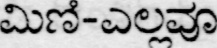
ಮಿಣಿ-ಎಲ್ಲವೂ
